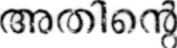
അതിന്റെ
